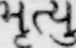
મૃત્યુ
